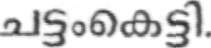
ചട്ടംകെട്ടി.
